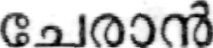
ചേരാന്‍
